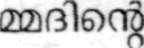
മ്മദിന്റെ
